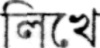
লিখে
